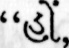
"હોં,
